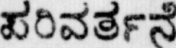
ಪರಿವರ್ತನೆ
